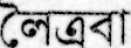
লৈত্রবা
